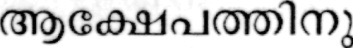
ആക്ഷേപത്തിനു
